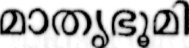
മാതൃഭൂമി
